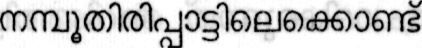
നമ്പൂതിരിപ്പാട്ടിലെക്കൊണ്ട്
